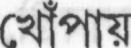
খোঁপায়
